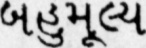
બહુમૂલ્ય
